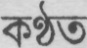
কণ্ঠত
